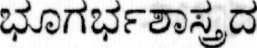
ಭೂಗರ್ಭಶಾಸ್ತ್ರದ
